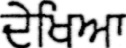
ਦੇਖਿਆ
